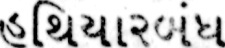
હથિયારબંધ
